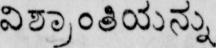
ವಿಶ್ರಾಂತಿಯನ್ನು
